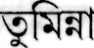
তুমিন্না
